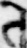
તે
